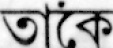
তাকে
